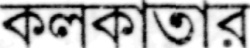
কলকাতার
